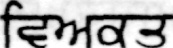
ਵਿਅਕਤ
